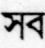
সব
